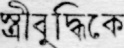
স্ত্রীবুদ্ধিকে
